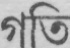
গতি
